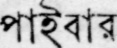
পাইবার
